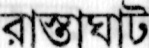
রাস্তাঘাট
